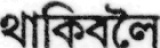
থাকিবলৈ
